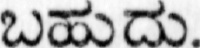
ಬಹುದು.
